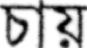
চায়
